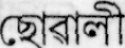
ছোৱালী
